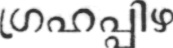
ഗ്രഹപ്പിഴ
